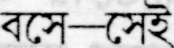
বসে—সেই
